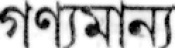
গণ্যমান্য
